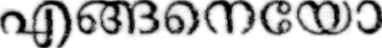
എങ്ങനെയോ
